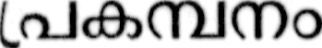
പ്രകമ്പനം
